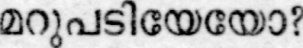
മറുപടിയേയോ?
